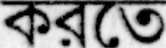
করতে
